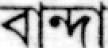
বান্দা
